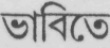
ভাবিতে
